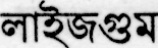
লাইজগুম
